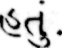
હતું.
